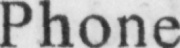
Phone
